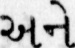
અને
